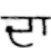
ਦਾ
